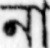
না
